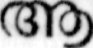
ആ
